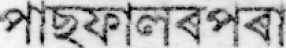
পাছফালৰপৰা
